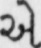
એ
